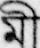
মী
